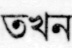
তখন
